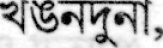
খঙনদুনা,
